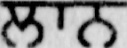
ਲਾਨ
